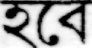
হবে
